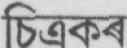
চিত্রকৰ
